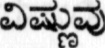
ವಿಷ್ಣುವು
